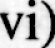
vi)
